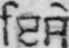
ਇਸੇ
